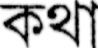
কথা
